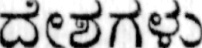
ದೇಶಗಳು
